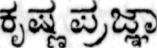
ಕೃಷ್ಣಪ್ರಜ್ಞಾ
